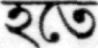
হতে
